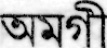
অমগী
